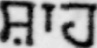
ਸ਼ਾਹ
